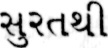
સુરતથી
